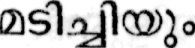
മടിച്ചിയും
